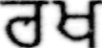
ਰਖ
